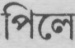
পিলে
